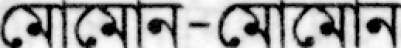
মোমোন-মোমোন
